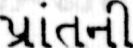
પ્રાંતની
